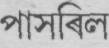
পাসৰিল
